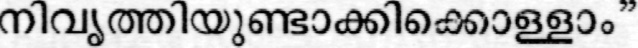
നിവൃത്തിയുണ്ടാക്കിക്കൊള്ളാം”
